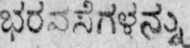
ಭರವಸೆಗಳನ್ನು
